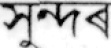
সুন্দৰ
